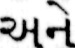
અને
